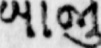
બાજુ
